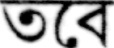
তবে
